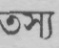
তস্য
